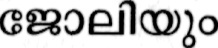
ജോലിയും
